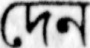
দেন
